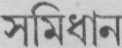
সমিধান
